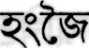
হংজৈ
